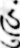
હું
